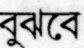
বুঝবে
